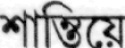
শান্তিয়ে
